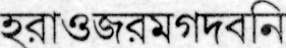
হরাওজরমগদবনি
